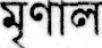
মৃণাল
